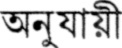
অনুযায়ী
